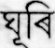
ঘূৰি
